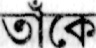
তাঁকে
